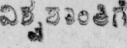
ವಿಶ್ವಶಾಂತಿಗೆ
